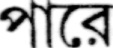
পারে
